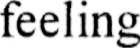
feeling
